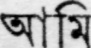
আমি
